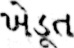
ખેડૂત
